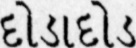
દોડાદોડ
